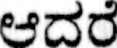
ಆದರೆ
